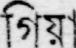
গিয়া
